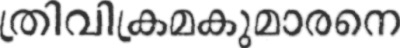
ത്രിവിക്രമകുമാരനെ
